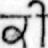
ਕੀ
